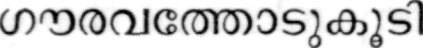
ഗൌരവത്തോടുകൂടി
